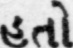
હતો
